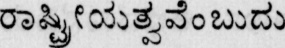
ರಾಷ್ಟ್ರೀಯತ್ವವೆಂಬುದು
